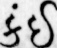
કંઈ
